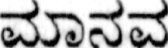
ಮಾನವ
